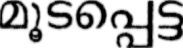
മൂടപ്പെട്ട
